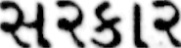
સરકાર
